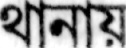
থানায়
